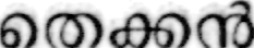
തെക്കന്‍
